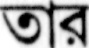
তার
